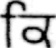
ਕਿ
